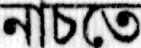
নাচতে
